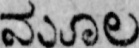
ಮೂಲ
